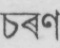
চৰণ
